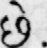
છે.
